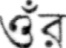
ওঁর
